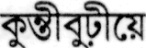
কুন্তীবুঢ়ীয়ে
